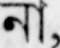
না,
